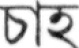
চাহ
